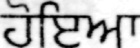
ਹੋਇਆ
